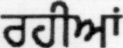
ਰਹੀਆਂ
